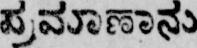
ಪ್ರಮಾಣಾನು
